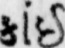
કાંઈ
